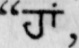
''ਹਾਂ,
